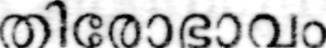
തിരോഭാവം
